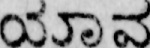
ಯಾವ
